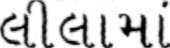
લીલામાં
